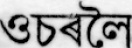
ওচৰলৈ
